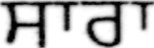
ਸਾਰਾ
